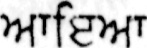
ਆਇਆ
